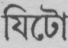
যিটো
